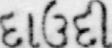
દાઉદી
